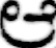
ಆ
